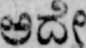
ಅದೇ
